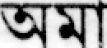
অমা
